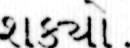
શક્યો.
